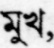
মুখ,
